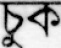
চুক
